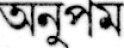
অনুপম
